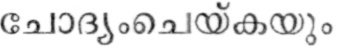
ചോദ്യംചെയ്കയും
